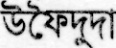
উফৈদুদা
